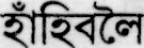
হাঁহিবলৈ
